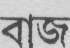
বাজ
